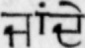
ਜਾਂਦੇ
